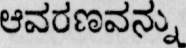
ಆವರಣವನ್ನು
